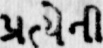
પ્રત્યેની
